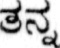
ತನ್ನ
